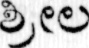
ಶ್ರೀಲ
